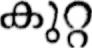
കുറ്റ
